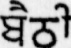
ਬੈਠੀ
